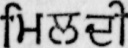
ਮਿਲਦੀ
